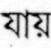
যায়
